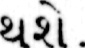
થશે.
